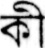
কী
